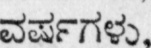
ವರ್ಷಗಳು,
